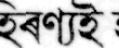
হিৰণ্যই
